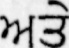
ਅਤੇ
